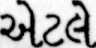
એટલે
